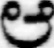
ಆ
